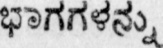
ಭಾಗಗಳನ್ನು
